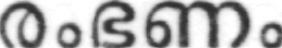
രംഭണം
